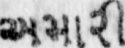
અમારી
